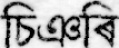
চিঞৰি
